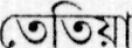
তেতিয়া
